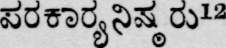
ಪರಕಾರ್‍ಯನಿಷ್ಠರು12
